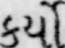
કર્યો
